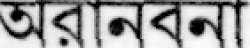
অরানবনা
